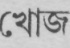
খোজ
